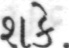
શકે.
